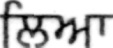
ਲਿਆ
